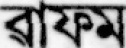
ৱাফম
